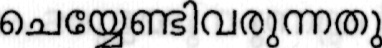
ചെയ്യേണ്ടിവരുന്നതു
